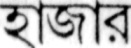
হাজার
